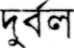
দুর্বল
